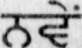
ਨਵੇਂ
